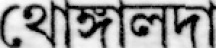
থোঙ্গালদা
